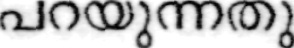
പറയുന്നതു
